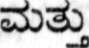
ಮತ್ತು
